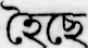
হৈছে
